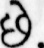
છે.
